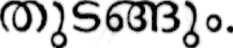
തുടങ്ങും.
